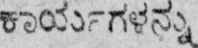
ಕಾರ್ಯಗಳನ್ನು
